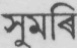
সুমৰি
